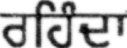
ਰਹਿੰਦਾ
